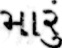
મારું
